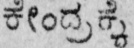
ಕೇಂದ್ರಕ್ಕೆ
